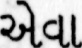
એવા
